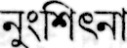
নুংশিৎনা
